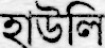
হাউলি
